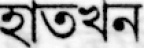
হাতখন
